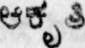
ಆಕೃತಿ
